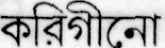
করিগীনো
